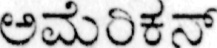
ಅಮೆರಿಕನ್
